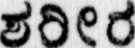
ಶರೀರ
